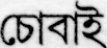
চোবাই
